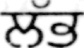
ਲੱਭ
